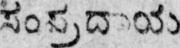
ಸಂಪ್ರದಾಯ
